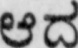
ಆದ
